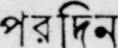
পরদিন
